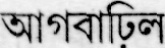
আগবাঢ়িল
